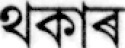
থকাৰ
